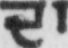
ਦਾ
